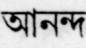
আনন্দ
